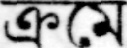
ক্রমে
